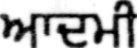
ਆਦਮੀ
